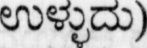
ಉಳ್ಳುದು)
